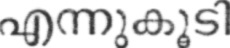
എന്നുകൂടി
